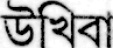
উখিবা
